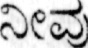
ನೀವು
